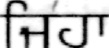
ਜਿਹਾ
